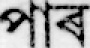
পাৰ
